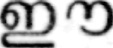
ഈ
